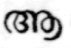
ആ
